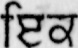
ਇਕ
